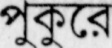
পুকুরে
